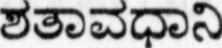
ಶತಾವಧಾನಿ
